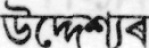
উদ্দেশ্যৰ
